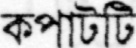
কপাটটি
